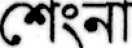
শেংনা
